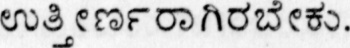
ಉತೀರ್ಣರಾಗಿರಬೇಕು.
